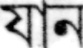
যান
